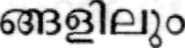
ങ്ങളിലും
